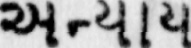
અન્યાય
